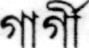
গার্গী
